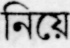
নিয়ে
